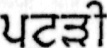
ਪਟੜੀ
